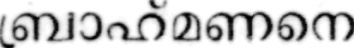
ബ്രാഹ്മണനെ
